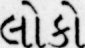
લોકો
